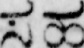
ಸಹ
